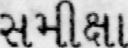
સમીક્ષા
